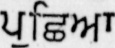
ਪੁਛਿਆ
